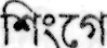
শিংগে
